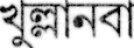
খুল্লানবা
